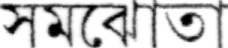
সমঝোতা
